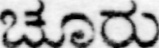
ಚೂರು
